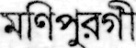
মণিপুরগী
